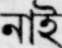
নাই
